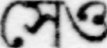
সেও
